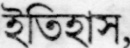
ইতিহাস,
